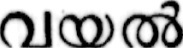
വയല്‍
